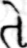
તે
